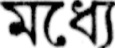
মধ্যে
